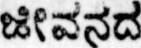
ಜೀವನದ
